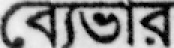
ব্যেভার
